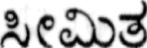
ಸೀಮಿತ
